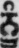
ਨੂੰ
